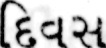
દિવસ
